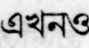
এখনও
